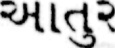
આતુર
